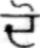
ਦੋ
